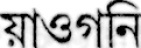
য়াওগনি
